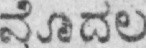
ಮೊದಲ
